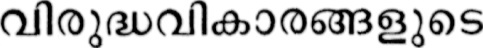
വിരുദ്ധവികാരങ്ങളുടെ
